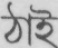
ঠাই
